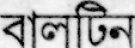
বালটিন
